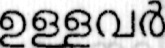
ഉള്ളവര്‍
